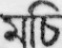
মচি
